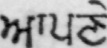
ਆਪਣੇ
